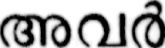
അവര്‍
